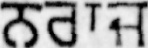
ਨਰਾਜ
